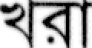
খরা
